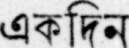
একদিন
